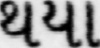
થયા
